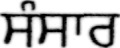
ਸੰਸਾਰ
